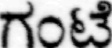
ಗಂಟೆ
